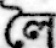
লৈ
